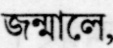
জন্মালে,
